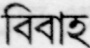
বিবাহ
